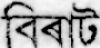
বিৰাট
